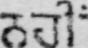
ਨਹੀਂ
